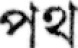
পথ
